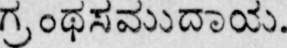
ಗ್ರಂಥಸಮುದಾಯ.
